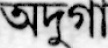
অদুগা
